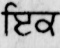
ਇਕ
